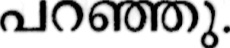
പറഞ്ഞു.
